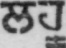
ਲਹੂ
